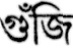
গুঁজি
